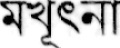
মখূৎনা
